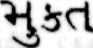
મુક્ત
